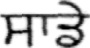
ਸਾਡੇ
